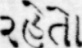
રહેતો
